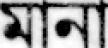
মানা
